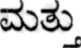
ಮತ್ತು
